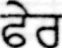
ਫੇਰ
